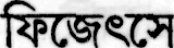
ফিজেৎসে
